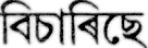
বিচাৰিছে
